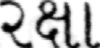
રક્ષા
